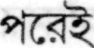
পরেই
